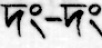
দং-দং
